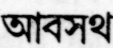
আবসথ
